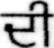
ਦੀ
